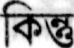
কিন্তু
